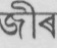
জীৰ
